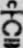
ਨੂੰ
